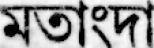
মতাংদা
